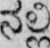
ನಲ್ಲಿ
